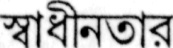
স্বাধীনতার
